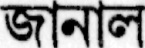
জানাল
